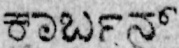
ಕಾರ್ಬನ್
